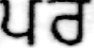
ਪਰ
